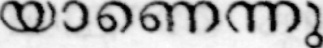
യാണെന്നു
